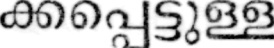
ക്കപ്പെട്ടുള്ള
